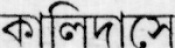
কালিদাসে
